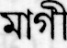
মাগী
